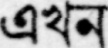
এখন
